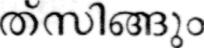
ത്സിങ്ങും
